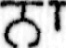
ਨਾ
